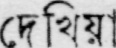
দেখিয়া
